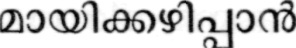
മായിക്കഴിപ്പാന്‍
